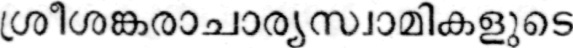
ശ്രീശങ്കരാചാര്യസ്വാമികളുടെ
